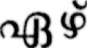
ഏഴ്
